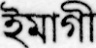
ইমাগী
